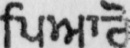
ਪਿਆਰੋ
